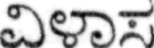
ವಿಳಾಸ
